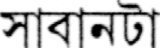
সাবানটা
